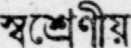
স্বশ্রেণীয়
